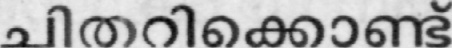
ചിതറിക്കൊണ്ട്
